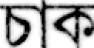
চাক
